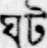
ঘট
